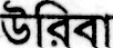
উরিবা
